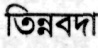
তিন্নবদা
